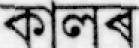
কালৰ
